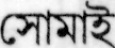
সোমাই
